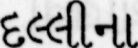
દલ્લીના
